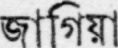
জাগিয়া
